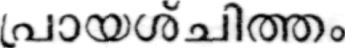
പ്രായശ്ചിത്തം
